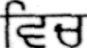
ਵਿਚ
